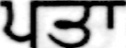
ਪਤਾ
